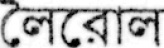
লৈরোল
